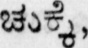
ಚುಕ್ಕೆ,
